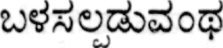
ಬಳಸಲ್ಪಡುವಂಥ
